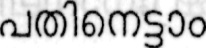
പതിനെട്ടാം
